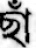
ছাঁ
